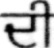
ਦੀ
